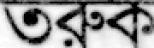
তরুক
